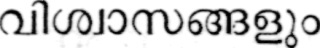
വിശ്വാസങ്ങളും
